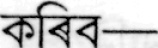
কৰিব-
